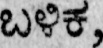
ಬಳಿಕ,
